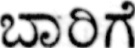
ಬಾರಿಗೆ
